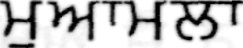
ਮੁਆਮਲਾ
